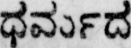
ಧರ್ಮದ
